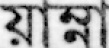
য়াম্না
